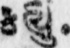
કહ્યું.
